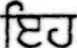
ਇਹ
